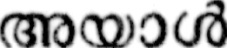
അയാള്‍
